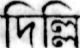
দিল্লি
